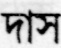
দাস
